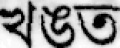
খঙত
